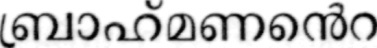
ബ്രാഹ്മണന്റെ
